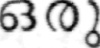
ഒരു
